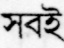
সবই
